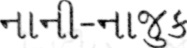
નાની-નાજુક
